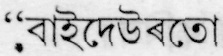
"বাইদেউৰতো
